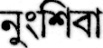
নুংশিবা
